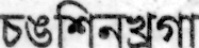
চঙশিনখ্রগা
